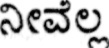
ನೀವೆಲ್ಲ
